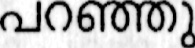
പറഞ്ഞു
